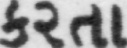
કરતા
